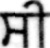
ਸੀ
